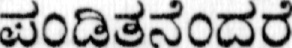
ಪಂಡಿತನೆಂದರೆ
